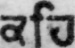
ਕਹਿ
